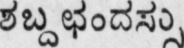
ಶಬ್ದಛಂದಸ್ಸು
